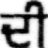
ਦੀ
